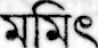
মমিৎ
